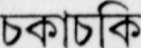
চকাচকি
